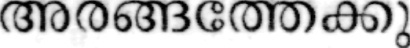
അരങ്ങത്തേക്കു
